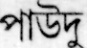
পাউদু
